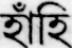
হাঁহি
